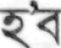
হ'ব
